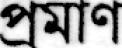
প্রামাণ
